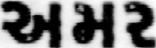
અમર
